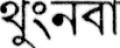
থুংনবা
